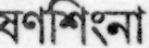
ষণশিংনা
